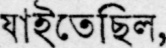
যাইতেছিল,
